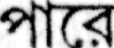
পারে
